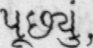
પૂછ્યું,
